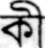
কী
